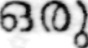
ഒരു
